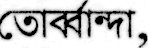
তোর্ব্বান্দা,
